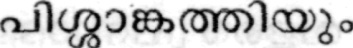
പിശ്ശാങ്കത്തിയും
